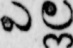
ಎಲ್ಲ
